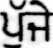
ਪੁੱਜੇ
